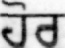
ਹੋਰ
